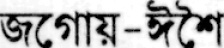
জগোয়-ঈশৈ
